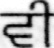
ਵੀ
